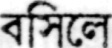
বসিলে
